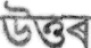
উত্তৰ
